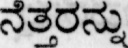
ನೆತ್ತರನ್ನು
